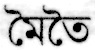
মৈতৈ
